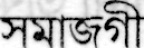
সমাজগী
